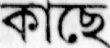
কাছে
